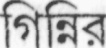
গিন্নির
